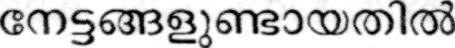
നേട്ടങ്ങളുണ്ടായതില്‍
